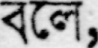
বলে,
